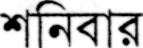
শনিবার
